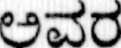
ಅವರ
